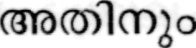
അതിനും
